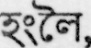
হংলৈ,
